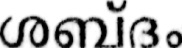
ശബ്ദം
